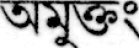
অমুক্তা
